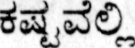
ಕಷ್ಟವೆಲ್ಲಿ
